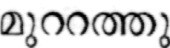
മുററത്തു
